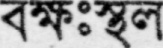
বক্ষঃস্থল
